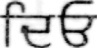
ਦਿਓ
